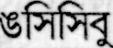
ঙসিসিবু
